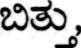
ಬಿತ್ತು,
